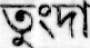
তুংদা
